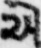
એ
